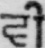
ਵੀ
